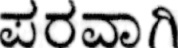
ಪರವಾಗಿ
